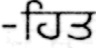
-ਹਿਤ
